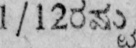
1/12ರಷ್ಟು
